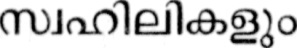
സ്വഹിലികളും
